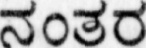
ನಂತರ
